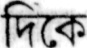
দিকে
